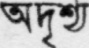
অদৃশ্য
